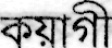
কয়াগী
